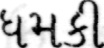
ધમકી
